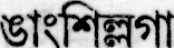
ঙাংশিল্লগা
